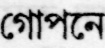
গোপনে
